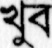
খুব
